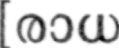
[രാധ
